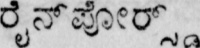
ರೈನ್‌ಪೋರ್‍ಸ್ಡ್
